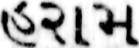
હરામ
